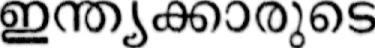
ഇന്ത്യക്കാരുടെ
